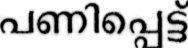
പണിപ്പെട്ട്
